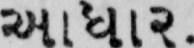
આધાર.
